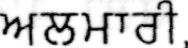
ਅਲਮਾਰੀ,
